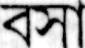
বসা
